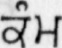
ਕੰਮ
